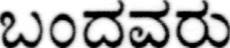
ಬಂದವರು
